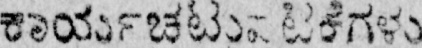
ಕಾರ್ಯಚಟುವಟಿಕೆಗಳು
